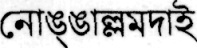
নোঙঙাল্লমদাই
